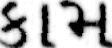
કામ
